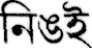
নিঙই
